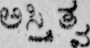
ಅಸ್ತಿತ್ವ
